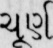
ચૂર્ણ
